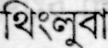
থিংলুবা
